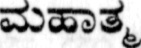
ಮಹಾತ್ಮ
